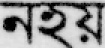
নহয়
